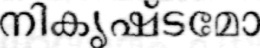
നികൃഷ്ടമോ
